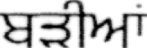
ਬੜੀਆਂ
